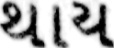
થાય
